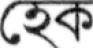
হেক
